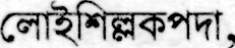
লোইশিল্লকপদা,
